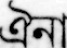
ঐনা
